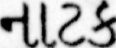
નાટક
